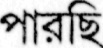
পারছি
